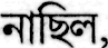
নাছিল,
